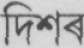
দিশৰ
